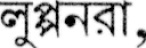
লুপ্পনরা,
